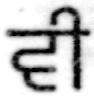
ਵੀ
